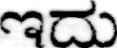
ಇದು
